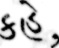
કહે,
